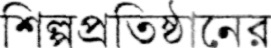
শিল্পপ্রতিষ্ঠানের
